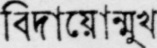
বিদায়োন্মুখ
